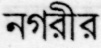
নগরীর
